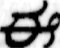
ಈ
